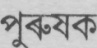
পুৰুষক
